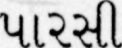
પારસી
